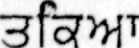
ਤਕਿਆ
